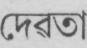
দেৱতা
